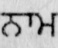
ਨਾਮ
